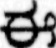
ಈ
